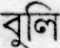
বুলি
